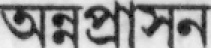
অন্নপ্রাসন
